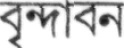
বৃন্দাবন
